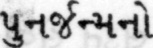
પુનર્જન્મનો
